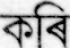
কৰি
